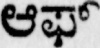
ಆಫ್
